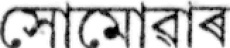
সোমোৱাৰ
